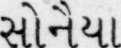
સોનૈયા
